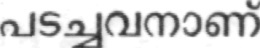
പടച്ചവനാണ്
